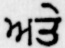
ਅਤੇ
